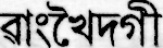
ৱাংখৈদগী
